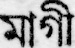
মাগী
